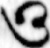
ও
